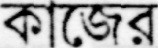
কাজের
